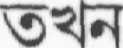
তখন
